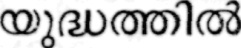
യുദ്ധത്തില്‍
